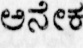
ಅನೇಕ
